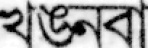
খঙনবা
